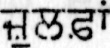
ਜ਼ੁਲਫਾਂ
